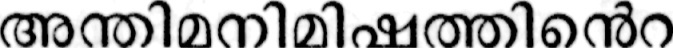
അന്തിമനിമിഷത്തിന്റെ
